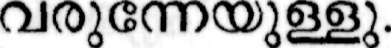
വരുന്നേയുള്ളു.
